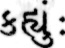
કહ્યું:
